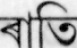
ৰাতি
